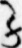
કે
